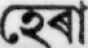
হেৰা
